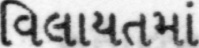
વિલાયતમાં
